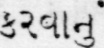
કરવાનું
